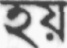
হয়
